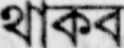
থাকব
